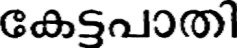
കേട്ടപാതി
